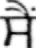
ਸੈਂ
